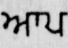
ਆਪ
